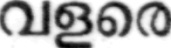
വളരെ
